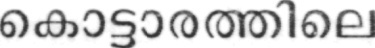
കൊട്ടാരത്തിലെ
